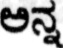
ಅನ್ನ
